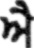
ਐ
